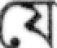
যে
